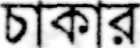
চাকার
